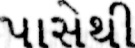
પાસેથી
